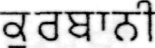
ਕੁਰਬਾਨੀ
